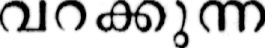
വറക്കുന്ന
